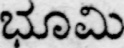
ಭೂಮಿ
